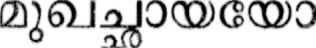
മുഖച്ഛായയോ
